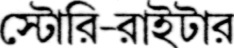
স্টোরি-রাইটার
